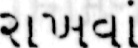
રાખવાં
